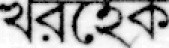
খরহেক
